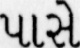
પાસે
